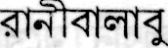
রানীবালাবু
